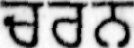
ਚਰਨ
